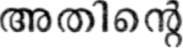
അതിന്റെ
